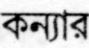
কন্যার
